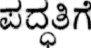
ಪದ್ಧತಿಗೆ
